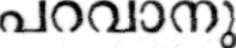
പറവാനു
